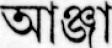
আঞ্জা
